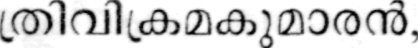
ത്രിവിക്രമകുമാരന്‍,
